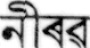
নীৰৱ
